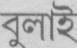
বুলাই
